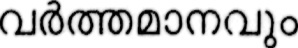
വര്‍ത്തമാനവും
